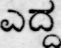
ಎದ್ದ
